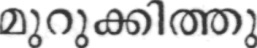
മുറുക്കിത്തു
